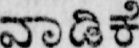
ವಾಡಿಕೆ
